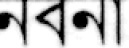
নবনা
